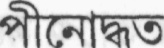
পীনোদ্ধত
